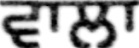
ਵਾਲਾ
